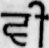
ਵੀ
